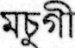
মচুগী
